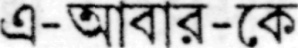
এ-আবার-কে
